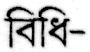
বিধি-
